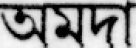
অমদা
